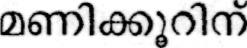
മണിക്കൂറിന്
